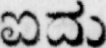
ಐದು
